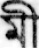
মী
